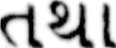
તથા
